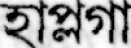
হাপ্লগা
